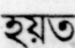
হয়ত
